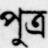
পুত্র
